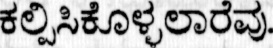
ಕಲ್ಪಿಸಿಕೊಳ್ಳಲಾರೆವು.
